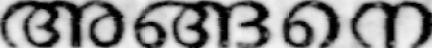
അങ്ങനെ
